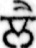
ਲੈ
